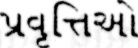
પ્રવૃત્તિઓ
